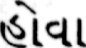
હોવા
